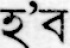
হ'ব
